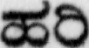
ಹರಿ
